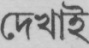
দেখাই
